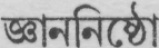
জ্ঞাননিষ্ঠো
